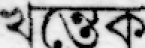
খন্তেক
